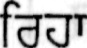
ਰਿਹਾ
